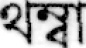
থম্বা
